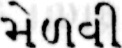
મેળવી
